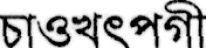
চাওখৎপগী
